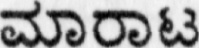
ಮಾರಾಟ
